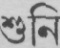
শুনি
